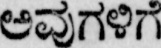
ಅವುಗಳಿಗೆ
